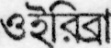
ওইরিব্রা
